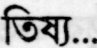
তিষ্য...
